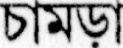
চামড়া
